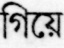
গিয়ে
